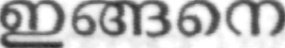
ഇങ്ങനെ
